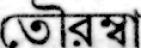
তৌরম্বা
